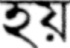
হয়
